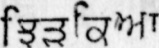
ਝਿੜਕਿਆ
